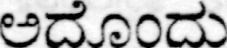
ಅದೊಂದು
